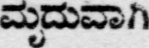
ಮೃದುವಾಗಿ
